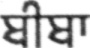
ਬੀਬਾ
